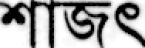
শাজৎ
